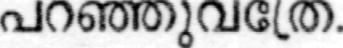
പറഞ്ഞുവത്രേ.
